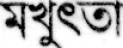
মখুৎতা
